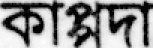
কাপ্পদা
